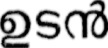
ഉടന്‍
